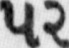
પર
